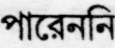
পারেননি
